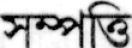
সম্পত্তি
